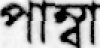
পাম্বা
